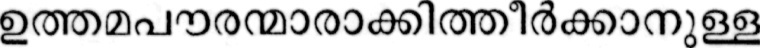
ഉത്തമപൌരന്മാരാക്കിത്തീര്‍ക്കാനുള്ള
